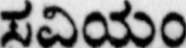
ಸವಿಯಂ
